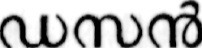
ഡസന്‍
